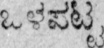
ಒಳಪಟ್ಟ
